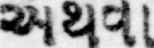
અથવા
